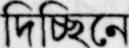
দিচ্ছিনে
